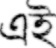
এই
